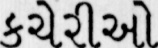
કચેરીઓ
